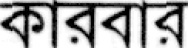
কারবার
